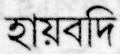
হায়বদি
